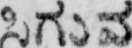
ಸಿಗುವ
